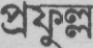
প্রফুল্ল
